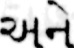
અને
